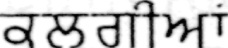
ਕਲਗੀਆਂ
